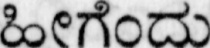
ಹೀಗೆಂದು
